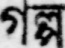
গল্প
